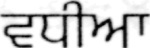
ਵਧੀਆ
